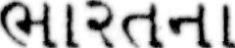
ભારતના
